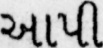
આપી
